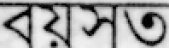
বয়সত
